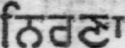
ਨਿਰਣਾ
